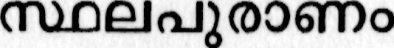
സ്ഥലപുരാണം
